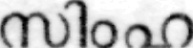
സിംഹ
